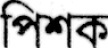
পিশক
